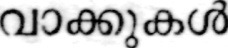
വാക്കുകള്‍
